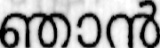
ഞാന്‍
